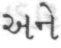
અને
